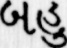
બહુ
